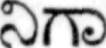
ನಿಗಾ
